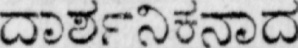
ದಾರ್ಶನಿಕನಾದ
